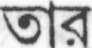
তার
